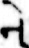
ને
